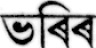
ভৰিৰ
